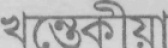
খন্তেকীয়া
